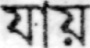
যায়
